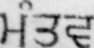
ਮੰਤਵ
